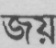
জয়
